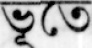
ভূতে
